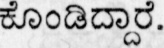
ಕೊಂಡಿದ್ದಾರೆ.
